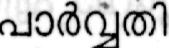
പാര്‍വ്വതി
